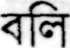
বলি
